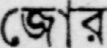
জোর
